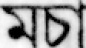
মচা
